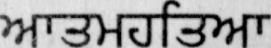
ਆਤਮਹਤਿਆ
